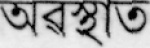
অৱস্হাত
